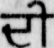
ਦੀ
